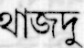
থাজদু
